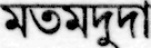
মতমদুদা
